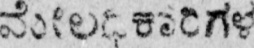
ಮೇಲಧಿಕಾರಿಗಳ
